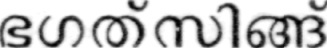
ഭഗത്‌സിങ്ങ്
